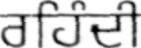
ਰਹਿੰਦੀ
